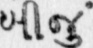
બીજું
